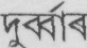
দুৰ্ব্বাৰ
